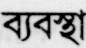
ব্যবস্থা
